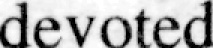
devoted
